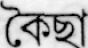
কৈছা
